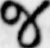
જ
